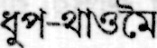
ধুপ-থাওমৈ
